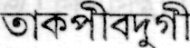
তাকপীবদুগী
